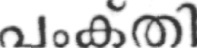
പംക്തി
